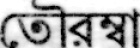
তৌরম্বা
